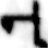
ન
